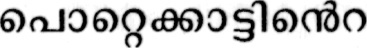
പൊറ്റെക്കാട്ടിന്റെ
